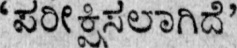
‘ಪರೀಕ್ಷಿಸಲಾಗಿದೆ’
